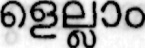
ളെല്ലാം
